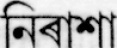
নিৰাশা
